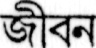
জীবন
